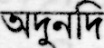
অদুনদি
